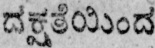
ದಕ್ಷತೆಯಿಂದ
